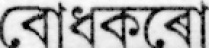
বোধকৰো
